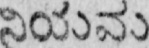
ನಿಯಮ
